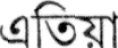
এতিয়া
